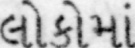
લોકોમાં
